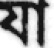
যা
